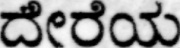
ದೇರೆಯ
